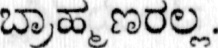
ಬ್ರಾಹ್ಮಣರಲ್ಲ.
